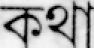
কথা
